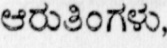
ಆರುತಿಂಗಳು,
